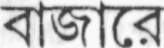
বাজারে
